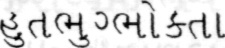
હુતભુગ્ભોકતા
